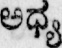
ಅಧ್ಯ
